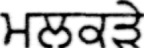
ਮਲਕੜੇ
